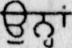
ਉਨ੍ਹਾਂ
